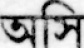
অসি
